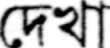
দেখা
